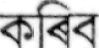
কৰিব
